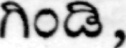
ಗಿಂಡಿ,
